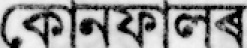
কোনফালৰ
